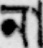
না
